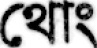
থোং
